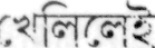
খেলিলেই
